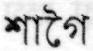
শাগৈ
